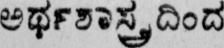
ಅರ್ಥಶಾಸ್ತ್ರದಿಂದ
